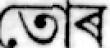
তোৰ
